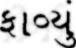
ફાવ્યું
